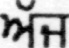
ਅੱਜ
